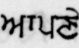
ਆਪਣੇ
